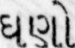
ઘણો
